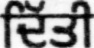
ਦਿੱਤੀ
